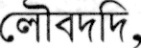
লৌবদদি
